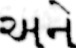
અને
